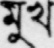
মুখ
